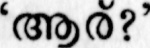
‘ആര്?’
